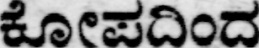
ಕೋಪದಿಂದ
